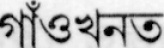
গাঁওখনত
